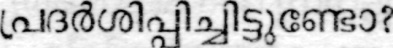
പ്രദര്‍ശിപ്പിച്ചിട്ടുണ്ടോ?
